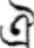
ঐ
